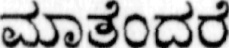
ಮಾತೆಂದರೆ
